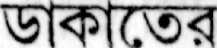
ডাকাতের
